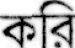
করি
